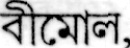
বীমোল,
